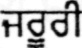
ਜਰੂਰੀ
